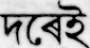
দৰেই
